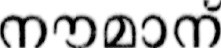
നൌമാന്
